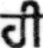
ਹੀ
